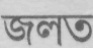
জলত
